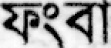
ফংবা
